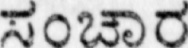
ಸಂಚಾರ
